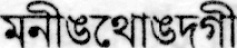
মনীঙথোঙদগী
